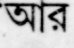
‘আর
